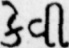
કેવી
